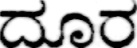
ದೂರ
